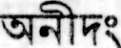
অনীদং
